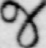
જ
